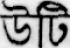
উটি
